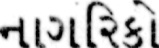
નાગરિકો
